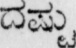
ದಷ್ಟು
